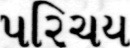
પરિચય
